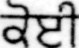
ਕੋਈ
